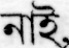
নাই,
